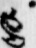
હું
